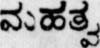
ಮಹತ್ವ
